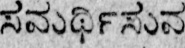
ಸಮರ್ಥಿಸುವ
